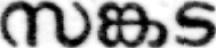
സങ്കട
